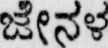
ಜೇನಳ
